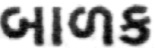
બાળક
